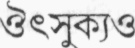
ঔত্সুক্যও
